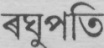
ৰঘুপতি
